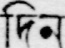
দিন
